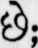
છે;
